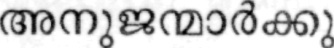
അനുജന്മാര്‍ക്കു
